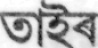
তাইৰ
